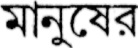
মানুষের
